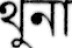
থুনা
